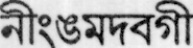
নীংঙমদবগী
